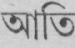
আতি
